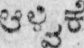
ಆಳ್ವಿಕೆ
